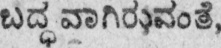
ಬದ್ಧವಾಗಿರುವಂತೆ,
